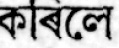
কৰিলে
